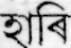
হাৰি
